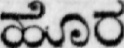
ಹೊರ
